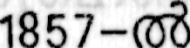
1857-ല്‍
